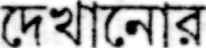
দেখানোর
